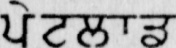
ਪੇਟਲਾਡ
